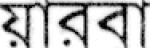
য়ারবা
